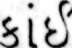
કાંઈ
